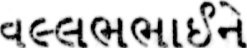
વલ્લભભાઈને
